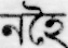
নহৈ
